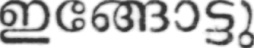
ഇങ്ങോട്ടു
